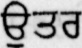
ਉਤਰ
